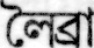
লৈব্রা
